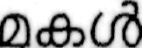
മകള്‍
